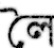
লৈ
